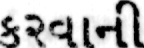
કરવાની
